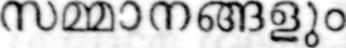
സമ്മാനങ്ങളും
